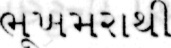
ભૂખમરાથી
